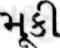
મૂકી
